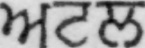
ਅਟਲ
